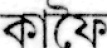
কাফৈ
